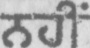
ਨਹੀਂ
